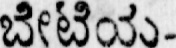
ಬೇಟೆಯ-
